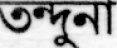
তন্দুনা
